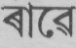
ৰাৱে
